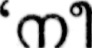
‘നീ
